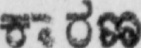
ಕಾರಣ
